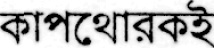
কাপথোরকই
